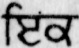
ਇਕ
